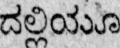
ದಲ್ಲಿಯೂ
